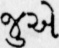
જુએ
